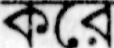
করে
